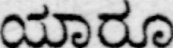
ಯಾರೂ
